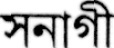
সনাগী
